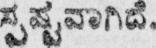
ಸ್ಪಷ್ಟವಾಗಿದೆ.
